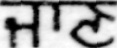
ਜਾਣ
